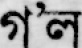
গ'ল
